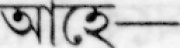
আহে-
